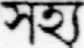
সহ্য
